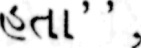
હતા",
